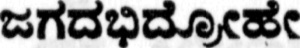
ಜಗದಭಿದ್ರೋಹೇ
